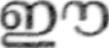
ഈ
